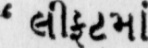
'લીફ્ટમાં
